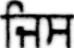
ਜਿਸ
